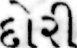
દોરી
